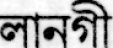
লানগী
